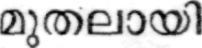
മുതലായി
